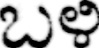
ಬಳಿ
